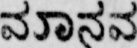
ಮಾನವ
